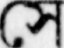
সে
